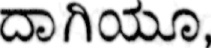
ದಾಗಿಯೂ,
